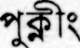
পুক্নীং
